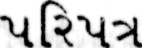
પરિપત્ર
